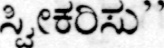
ಸ್ವೀಕರಿಸು"
